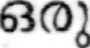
ഒരു
